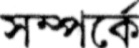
সম্পর্কে
